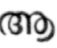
ആ
